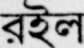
রইল
